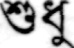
শুধু
